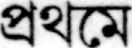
প্রথমে
